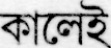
কালেই
